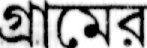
গ্রামের
